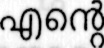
എന്റെ
